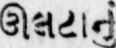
ઊલટાનું
